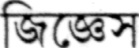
জিজ্ঞেস
